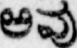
ಅವು
